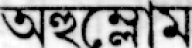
অহুম্লোম
